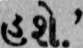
હશે.'
